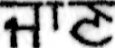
ਜਾਣ
